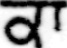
ਕਾ
